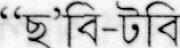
"ছ'বি-টবি
